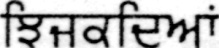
ਝਿਜਕਦਿਆਂ
